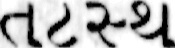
તટસ્થ
